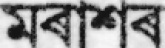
মৰাশৰ
